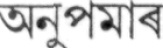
অনুপমাৰ
